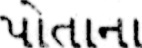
પોતાના
